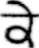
ਕੇ
